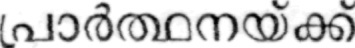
പ്രാര്‍ത്ഥനയ്ക്ക്
